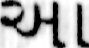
આ
